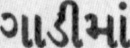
ગાડીમાં
